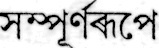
সম্পূর্ণৰূপে
